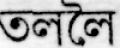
তললৈ
